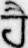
ਹੈ
